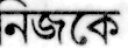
নিজকে
